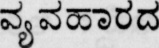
ವ್ಯವಹಾರದ
